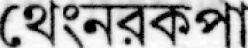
থেংনরকপা
